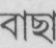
বাছা
